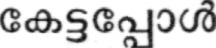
കേട്ടപ്പോള്‍
